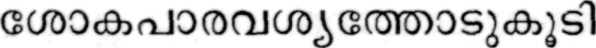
ശോകപാരവശ്യത്തോടുകൂടി
